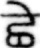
ਛੇ
